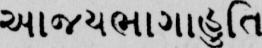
આજ્યભાગાહુતિ
